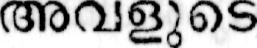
അവളുടെ
